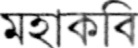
মহাকবি
